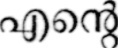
എന്റെ
